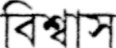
বিশ্বাস
